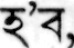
হ'ব,
